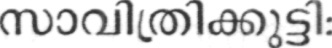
സാവിത്രിക്കുട്ടി:
